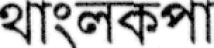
থাংলকপা
